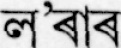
ল'ৰাৰ
